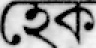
হেক
